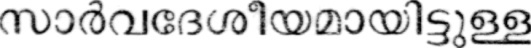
സാര്‍വദേശീയമായിട്ടുള്ള
